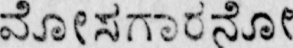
ಮೋಸಗಾರನೋ
